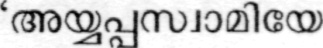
‘അയ്യപ്പസ്വാമിയേ
